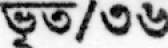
ভুত/৩৬
